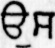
ਉਸ
